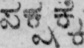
ಪಕ್ಷಕ್ಕೆ
